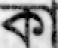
কা
